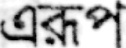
এরূপ
